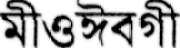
মীওঈবগী
